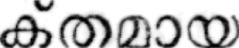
ക്തമായ
